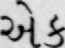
એક
